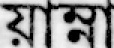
য়াম্না
